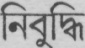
নিবুদ্ধি
